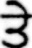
ਤੇ
